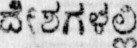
ದೇಶಗಳಲ್ಲಿ
